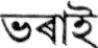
ভৰাই
